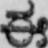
ಈ
